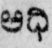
ಅಧಿ
